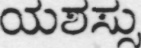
ಯಶಸ್ಸು
